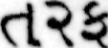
તરફ
